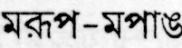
মরূপ-মপাঙ
